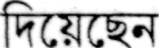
দিয়েছেন
